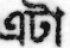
এটা
